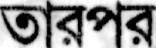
তারপর
